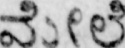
ಮೇಲೆ
